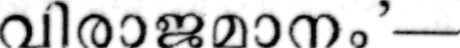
വിരാജമാനം'-
